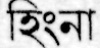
হিংনা
